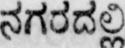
ನಗರದಲ್ಲಿ
